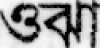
ওঝা
